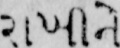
રાખીને
